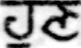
ਹੁਣ
